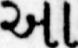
આ
